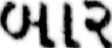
બાર
